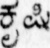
ಕೃಷಿ
